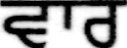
ਵਾਰ
